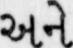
અને
